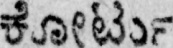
ಕೋರ್ಟು
